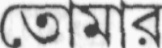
তোমার
